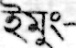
ইমুং-
